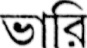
ভারি
